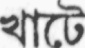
খাটে
